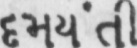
દમંયતી
